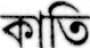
কাতি
